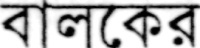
বালকের
